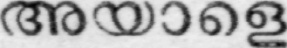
അയാളെ
